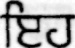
ਇਹ
